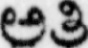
ಅತಿ
